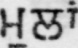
ਮੁਲਾਂ
